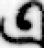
এ
